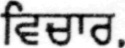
ਵਿਚਾਰ,
